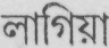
লাগিয়া
